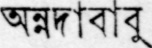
অন্নদাবাবু
